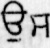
ਉਸ
